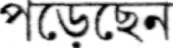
পড়েছেন
